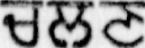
ਚਲਣ
